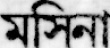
মসিনা
